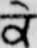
ਕੇ
